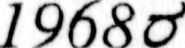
1968ರ
